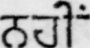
ਨਹੀਂ
